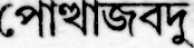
পোত্থাজবদু
